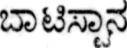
ಬಾಟಿಸ್ಟಾನ
